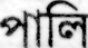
পালি
